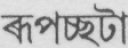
ৰূপচ্ছটা
